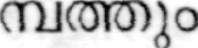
മ്പത്തും
